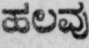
ಹಲವು
